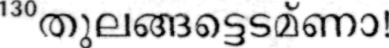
130തുലങ്ങട്ടെടമ്ണാ!
